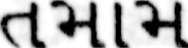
તમામ
